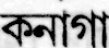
কনাগা
